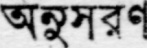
অনুসরণ
